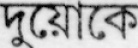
দুয়োকে
